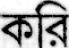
করি
